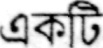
একটি
